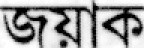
জয়াক
